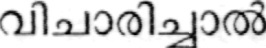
വിചാരിച്ചാല്‍
